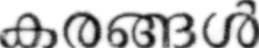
കരങ്ങള്‍
